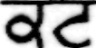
ਕਟ
